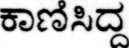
ಕಾಣಿಸಿದ್ದ
